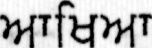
ਆਖਿਆ
